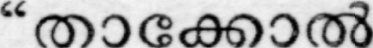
"താക്കോല്‍
